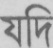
যদি
